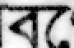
ব
